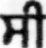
ਸੀ
